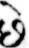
છે
